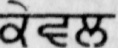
ਕੇਵਲ
